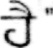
ਹੈ''
